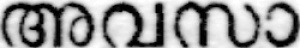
അവസാ
